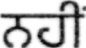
ਨਹੀਂ
